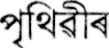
পৃথিৱীৰ
